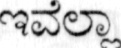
ಇವೆಲ್ಲಾ
